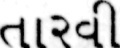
તારવી
